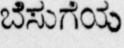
ಬೆಸುಗೆಯ
